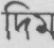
দিম
